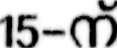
15-ന്
